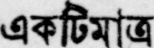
একটিমাত্র
